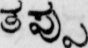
ತಪ್ಪು
